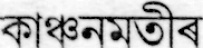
কাঞ্চনমতীৰ
